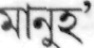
মানুহ'
